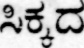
ಸಿಕ್ಕದ
